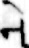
ને
